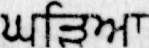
ਘੜਿਆ
